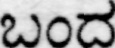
ಬಂದ
